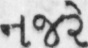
નજરે
